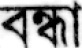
বন্ধা
